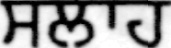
ਸਲਾਹ
